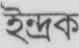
ইন্দ্ৰক
